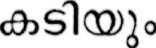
കടിയും
